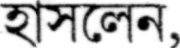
হাসলেন,
